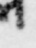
જો
